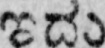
ಇದು
